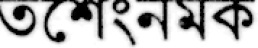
তশেংনমক
